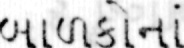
બાળકોનાં
